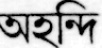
অহন্দি
